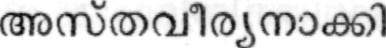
അസ്തവീര്യനാക്കി
